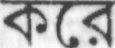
করে
